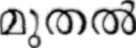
മുതല്‍
